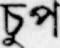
চুপ
